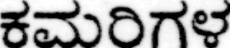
ಕಮರಿಗಳ
